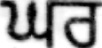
ਘਰ
